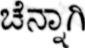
ಚೆನ್ನಾಗಿ
